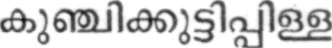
കുഞ്ചിക്കുട്ടിപ്പിള്ള
